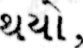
થયો,
